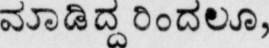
ಮಾಡಿದ್ದರಿಂದಲೂ,
